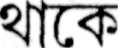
থাকে
